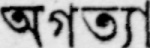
অগত্যা
